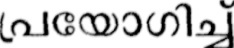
പ്രയോഗിച്ച്
